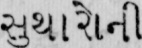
સુથારોની
